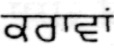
ਕਰਾਵਾਂ
